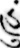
હું
